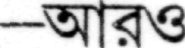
-আরও
